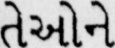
તેઓને
